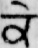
ਕੇ
